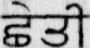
ਛੇਤੀ
